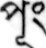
পূং
